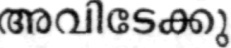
അവിടേക്കു
